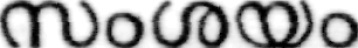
സംശയം
